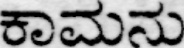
ಕಾಮನು
